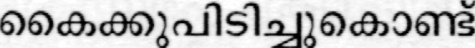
കൈക്കുപിടിച്ചുകൊണ്ട്
